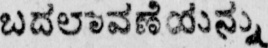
ಬದಲಾವಣೆಯನ್ನು
